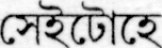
সেইটোহে
